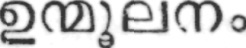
ഉന്മൂലനം
